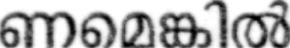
ണമെങ്കില്‍
